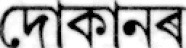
দোকানৰ
